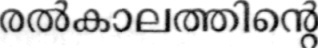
രല്‍കാലത്തിന്റെ
